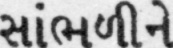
સાંભળીને
